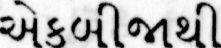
એકબીજાથી
